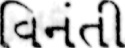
વિનંતી
